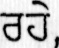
ਰਹੇ,
